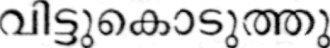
വിട്ടുകൊടുത്തു
